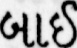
બાઈ
